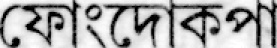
ফোংদোকপা
